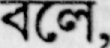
বলে,
